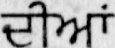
ਦੀਆਂ
